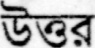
উত্তর
